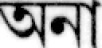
অনা
